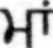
ਮਾਂ
